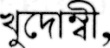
খুদোম্বী,
